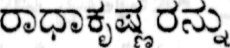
ರಾಧಾಕೃಷ್ಣರನ್ನು
